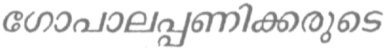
ഗോപാലപ്പണിക്കരുടെ
